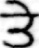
ਤੇ
